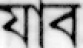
যাব
